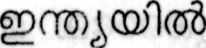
ഇന്ത്യയില്‍
